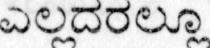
ಎಲ್ಲದರಲ್ಲೂ
